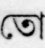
তো
